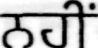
ਨਹੀਂ
